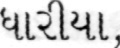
ધારીયા,
